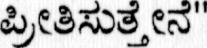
ಪ್ರೀತಿಸುತ್ತೇನೆ”
